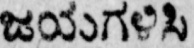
ಜಯಗಳಿಸಿ
